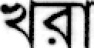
খরা
